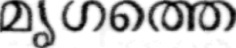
മൃഗത്തെ
